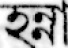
হন্না
